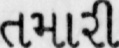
તમારી
